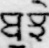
ਬੁਝੇ
